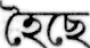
হৈছে
